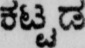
ಕಟ್ಟಡ
